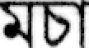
মচা
